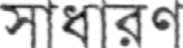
সাধারণ
